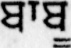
ਬਾਬੂ
